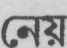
নেয়
